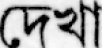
দেখা
